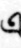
এ
